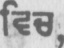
ਵਿਚ,
